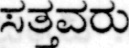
ಸತ್ತವರು
